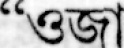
“ওজা
